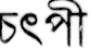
চৎপী
